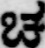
ಚ
